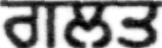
ਗਲਤ
